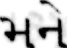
મને
